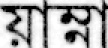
য়াম্না
